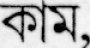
কাম,
